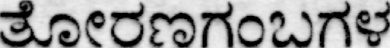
ತೋರಣಗಂಬಗಳ
